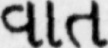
વાત
